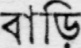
বাড়ি
